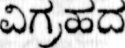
ವಿಗ್ರಹದ
